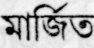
মার্জিত
